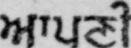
ਆਪਣੀ
